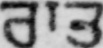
ਰਾਤ
